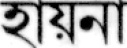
হায়না
